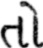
તો
